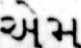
એમ
